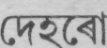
দেহৰো
